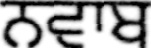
ਨਵਾਬ
